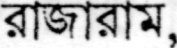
রাজারাম,
